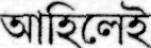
আহিলেই
